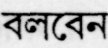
বলবেন
